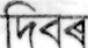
দিবৰ
